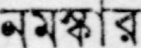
নমস্কার
